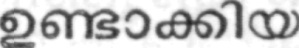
ഉണ്ടാക്കിയ
